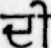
ਦੀ
